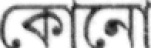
কোনো
